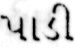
પાડી
